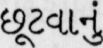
છૂટવાનું
